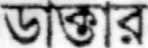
ডাক্তার
